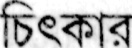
চিত্কার
